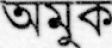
অমুক
